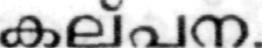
കല്പന.
